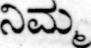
ನಿಮ್ಮ
